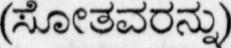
(ಸೋತವರನ್ನು)
